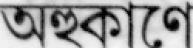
অহুকাণে
